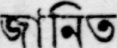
জানিত
